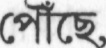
পৌঁছে,
